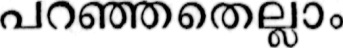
പറഞ്ഞതെല്ലാം
